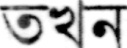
তখন
